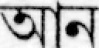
আন
